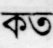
কত
